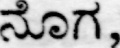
ನೊಗ,
